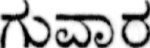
ಗುವಾರ
